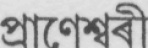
প্ৰাণেশ্বৰী
